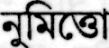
নুমিত্তো
